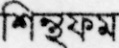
শিন্থফম
